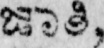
ಜಾತಿ,
